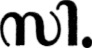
സി.
